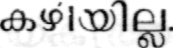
കഴിയില്ല.
